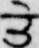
ਤੇ
